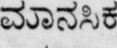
ಮಾನಸಿಕ
